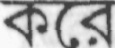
করে
